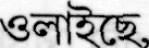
ওলাইছে,
